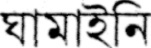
ঘামাইনি
